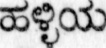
ಹಳ್ಳಿಯ
